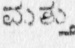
ಮತ್ತು
